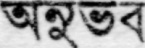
অনুভব
